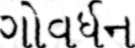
ગોવર્ધન
